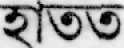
হাতত
